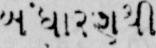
બંધારણથી
